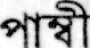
পাম্বী
